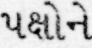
પક્ષોને
